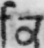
ਕਿ
